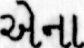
એના
